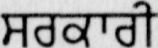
ਸਰਕਾਰੀ
